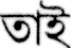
তাই
